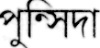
পুন্সিদা
